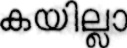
കയില്ലാ
